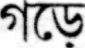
গড়ে
